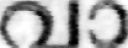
വാ
